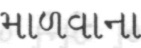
માળવાના
